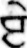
ਏ
